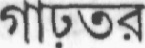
গাঢ়তর
